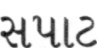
સપાટ
